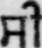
ਸੀ
